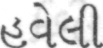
હવેલી
